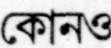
কোনও
